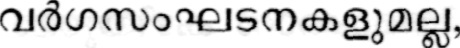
വര്‍ഗസംഘടനകളുമല്ല,
